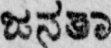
ಜನತಾ
